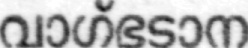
വാഗ്ഭടാന
